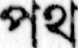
পথ
